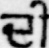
ਦੀ
